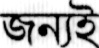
জন্যই
